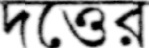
দত্তের
